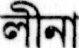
লীনা
